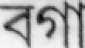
বগা
